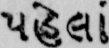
પહેલા
